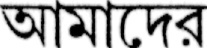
আমাদের
